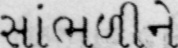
સાંભળીને
